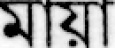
মায়া
